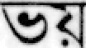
ভয়
